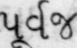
પૂર્વજ
